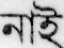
নাই
